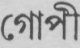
গোপী
